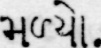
મળ્યો.
